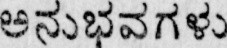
ಅನುಭವಗಳು
